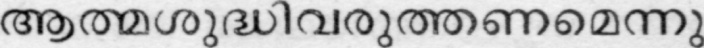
ആത്മശുദ്ധിവരുത്തണമെന്നു
